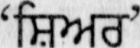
'ਸ਼ਿਅਰ'
